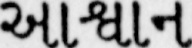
આશ્વાન
